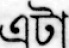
এটা
